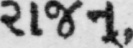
રાજન્,
